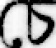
চে
